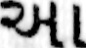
આ
